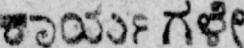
ಕಾರ್ಯಗಳೇ
